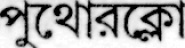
পুথোরক্লে
